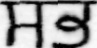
ਸਭ
